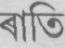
ৰাতি
